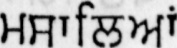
ਮਸਾਲਿਆਂ
